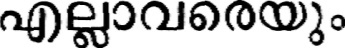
എല്ലാവരെയും
